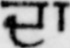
ਦਾ
